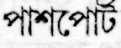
পাশপোর্ট
